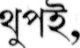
থুপই,
